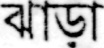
ঝাড়া
